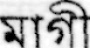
মাগী
